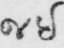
જઈ
